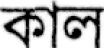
কাল
